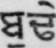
ਬੁਢੇ
